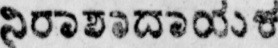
ನಿರಾಶಾದಾಯಕ
